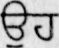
ਉਹ
